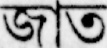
জাত
